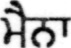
ਮੈਨਾ
